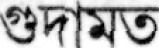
গুদামত
